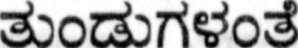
ತುಂಡುಗಳಂತೆ
